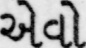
એવો
